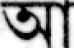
আ
